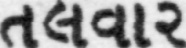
તલવાર
